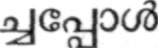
ച്ചപ്പോള്‍
